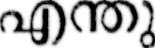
എന്തു
